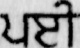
ਪਈ
